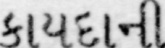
કાયદાની
